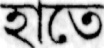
হাতে
